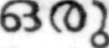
ഒരു
